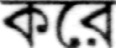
করে
